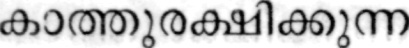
കാത്തുരക്ഷിക്കുന്ന
